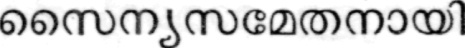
സൈന്യസമേതനായി
